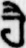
ਹੈ
